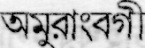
অমুরাংবগী
